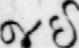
જઈ
